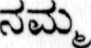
ನಮ್ಮ
